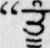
''ਤੂੰ
